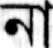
না
